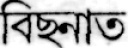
বিছনাত
